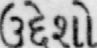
ઉદેશો
